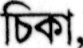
চিকা,
